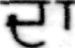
ਦਾ
